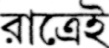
রাত্রেই
